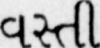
વસ્તી
